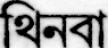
থিনবা
